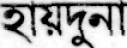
হায়দুনা
